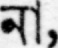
না,
